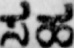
ಸಹ
